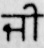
ਜੀ
